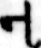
ન
